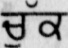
ਚੁੱਕ
